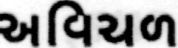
અવિચળ
